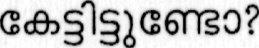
കേട്ടിട്ടുണ്ടോ?
